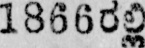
1866ರಲ್ಲಿ
